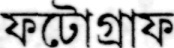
ফটোগ্রাফ
